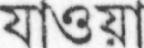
যাওয়া
